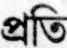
প্রতি
